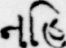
નહિ
